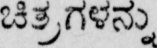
ಚಿತ್ರಗಳನ್ನು
